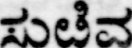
ಸುೞಿವ
